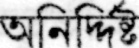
অনির্দ্দিষ্ট
